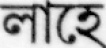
লাহে
